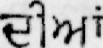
ਦੀਆਂ
